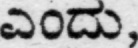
ಎಂದು,
